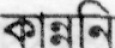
কান্ননি
